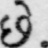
છે.
